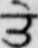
ਤੇ
